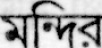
মন্দির
